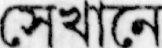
সেখানে
